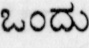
ಒಂದು
